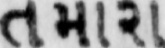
તમારા
